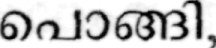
പൊങ്ങി,
